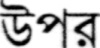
উপর
